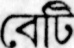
বেটি
